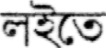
লইতে
